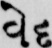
વેદ
